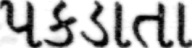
પકડાતા
